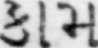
કામ
